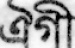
ঐগী
